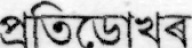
প্রতিডোখৰ
